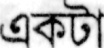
একটা
